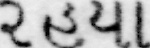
રહ્યા
